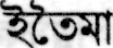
ইতৈমা
